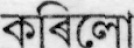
কৰিলো
